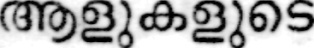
ആളുകളുടെ
